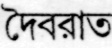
দৈবরাত
